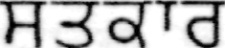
ਸਤਕਾਰ
